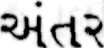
અંતર
